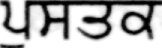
ਪੁਸਤਕ
